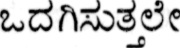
ಒದಗಿಸುತ್ತಲೇ
